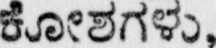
ಕೋಶಗಳು,
